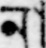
না
